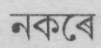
নকৰে
